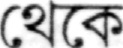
থেকে
